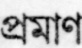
প্রমাণ
